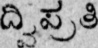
ದ್ವಿಪ್ರತಿ
